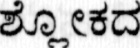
ಶ್ಲೋಕದ
